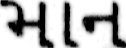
માન
